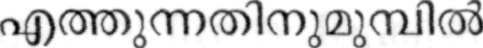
എത്തുന്നതിനുമുമ്പില്‍
